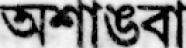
অশাঙবা
